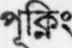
পূক্নিং
